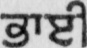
ਭਾਈ
